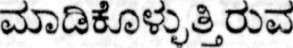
ಮಾಡಿಕೊಳ್ಳುತ್ತಿರುವ
